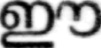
ഈ
